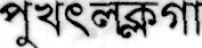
পুখৎলক্লগা
